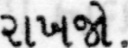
રાખજો.
